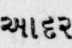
આદર
